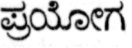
ಪ್ರಯೋಗ
